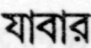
যাবার
